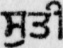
ਸੁਤੀ
